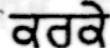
ਕਰਕੇ
